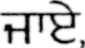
ਜਾਏ,
